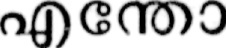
എന്തോ
